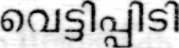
വെട്ടിപ്പിടി
